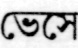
ভেসে
